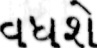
વધશે
